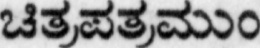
ಚಿತ್ರಪತ್ರಮುಂ
